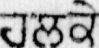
ਹਲਕੇ
